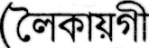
(লৈকায়গী
